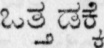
ಒತ್ತಡಕ್ಕೆ
